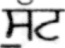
ਸੁੱਟ
